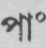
পা
